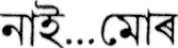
নাই...মোৰ
